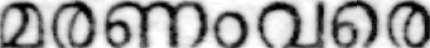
മരണംവരെ
